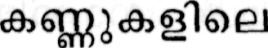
കണ്ണുകളിലെ
